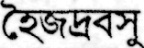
হৈজদ্রবসু
